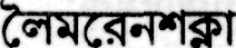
লৈমরেনশক্না
